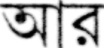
আর
